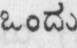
ಒಂದು
